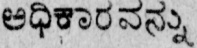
ಅಧಿಕಾರವನ್ನು
